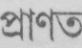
প্ৰাণত
